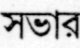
সভার
